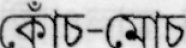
কোঁচ-মোচ
